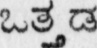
ಒತ್ತಡ
